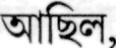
আছিল,
